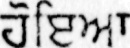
ਹੋਇਆ
